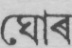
ঘোৰ
